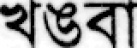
খঙবা
